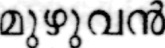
മുഴുവന്‍
